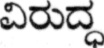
ವಿರುದ್ಧ
